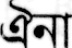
ঐনা
